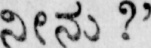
ನೀನು?’
